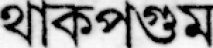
থাকপগুম
